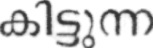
കിട്ടുന്ന
